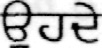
ਉਹਦੇ
